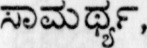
ಸಾಮರ್ಥ್ಯ,
